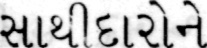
સાથીદારોને
